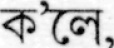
ক'লে,
